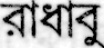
রাধাবু
